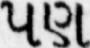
પણ
